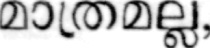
മാത്രമല്ല,
